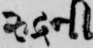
રુદ્રની
